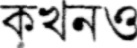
কখনও
